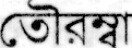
তৌরম্বা
